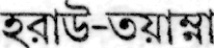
হরাউ-তয়াম্না
